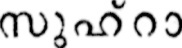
സുഹ്റാ
